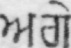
ਅਗੇ
